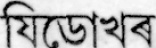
যিডোখৰ
